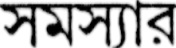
সমস্যার
